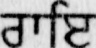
ਰਾਇ
